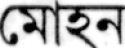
মোহন
